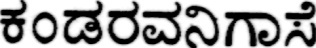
ಕಂಡರವನಿಗಾಸೆ
